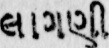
લાગણી
